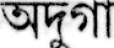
অদুগা
